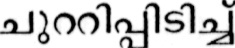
ചുററിപ്പിടിച്ച്
